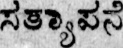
ಸತ್ಯಾಪನೆ
